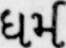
ધર્મ
